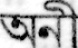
অনী
